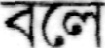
বলে
